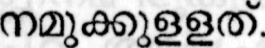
നമുക്കുളളത്.
